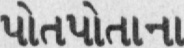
પોતપોતાના
